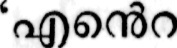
‘എന്റെ
